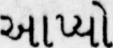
આપ્યો
